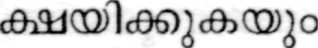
ക്ഷയിക്കുകയും
